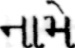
નામે
